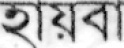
হায়বা
